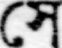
সে
